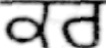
ਕਰ
